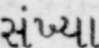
સંખ્યા
